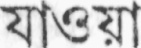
যাওয়া
